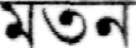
মতন
